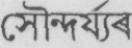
সৌন্দৰ্য্যৰ
